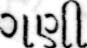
ગણી
